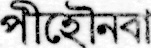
পীহৌনবা
